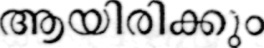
ആയിരിക്കും
